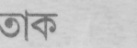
তাক
